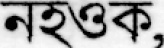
নহওক,
